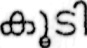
കൂടി
